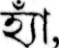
হ্যাঁ,
